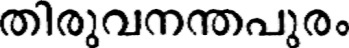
തിരുവനന്തപുരം
